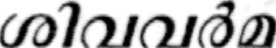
ശിവവര്‍മ
